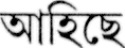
আহিছে
